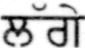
ਲੱਗੇ
